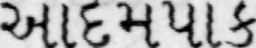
આદમપાક
